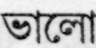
ভালো
